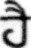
ਹੈ
